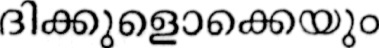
ദിക്കുളൊക്കെയും
